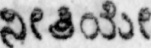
ನೀತಿಯೇ
